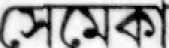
সেমেকা
